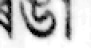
ৰঙা
